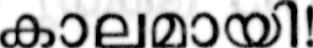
കാലമായി!
